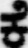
ಕೆ
